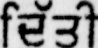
ਦਿੱਤੀ
